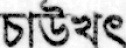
চাউখৎ
